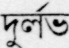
দুর্লভ
